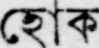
হোক
